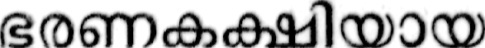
ഭരണകക്ഷിയായ
